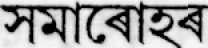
সমাৰোহৰ
